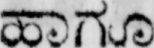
ಹಾಗೂ
